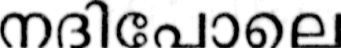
നദിപോലെ
